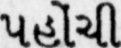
પહોંચી
